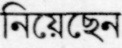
নিয়েছেন
